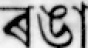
ৰঙা
